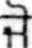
ਜੋ
